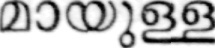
മായുള്ള
